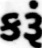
કરૂં
